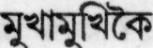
মুখামুখিকৈ
